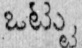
ಒಟ್ಟು
